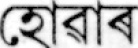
হোৱাৰ
